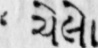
'ચેલો
